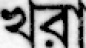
খরা
